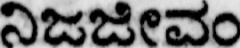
ನಿಜಜೀವಂ
